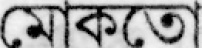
মোকতো
